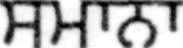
ਸਮਾਨਾ
